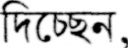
দিচ্ছেন,
